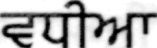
ਵਧੀਆ
